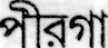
পীরগা
